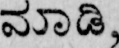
ಮಾಡಿ,
